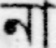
না
